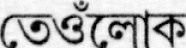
তেওঁলোক
